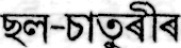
ছল-চাতুৰীৰ
